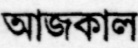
আজকাল
